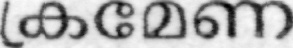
ക്രമേണ
